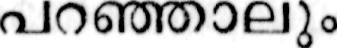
പറഞ്ഞാലും
